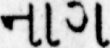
નાગ
